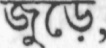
জুড়ে,
